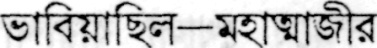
ভাবিয়াছিল—মহাত্মাজীর
